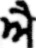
ਐ
